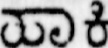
ಹಾಕಿ
